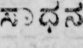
ಸಾಧನ
